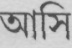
আসি
